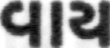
વાય
